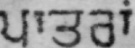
ਪਾਤਰਾਂ
